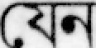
যেন
